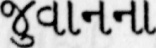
જુવાનના
